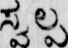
ಸ್ವಲ್ಪ
